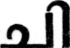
ചി
